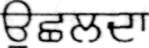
ਉਛਲਦਾ
